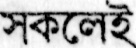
সকলেই
